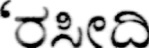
'ರಸೀದಿ
